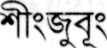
শীংজুবূং
